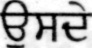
ਉਸਦੇ
